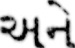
અને
